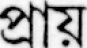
প্রায়
